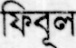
ফিবূল
